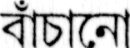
বাঁচানো
